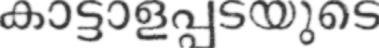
കാട്ടാളപ്പടയുടെ
